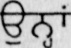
ਉਨ੍ਹਾਂ
